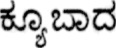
ಕ್ಯೂಬಾದ
